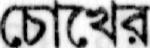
চোখের
